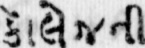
કૉલેજની
